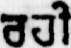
ਰਹੀ
